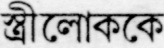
স্ত্রীলোককে
